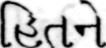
હિતને
